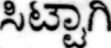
ಸಿಟ್ಟಾಗಿ
